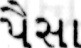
પૈસા
